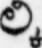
ಲ್ಕಿ
